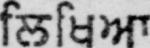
ਲਿਖਿਆ
